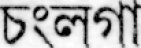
চংলগা
